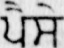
ਪੈਸੇ
